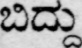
ಬಿದ್ದು
